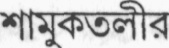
শামুকতলীর
